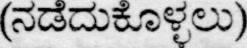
(ನಡೆದುಕೊಳ್ಳಲು)
